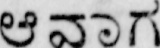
ಆವಾಗ
